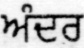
ਅੰਦਰ
